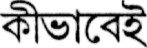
কীভাবেই
